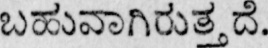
ಬಹುವಾಗಿರುತ್ತದೆ.
